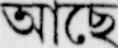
আছে
